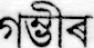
গম্ভীৰ
